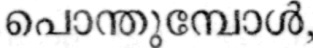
പൊന്തുമ്പോള്‍,
